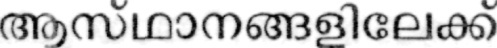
ആസ്ഥാനങ്ങളിലേക്ക്
